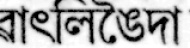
ৱাৎলিঙৈদা
